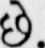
છે.
